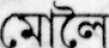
মোলৈ
